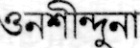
ওনশীন্দুনা
